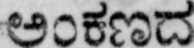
ಅಂಕಣದ
